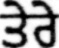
ਤੇਰੇ
